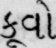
કૂવો
